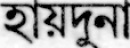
হায়দুনা
